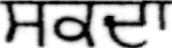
ਸਕਦਾ
